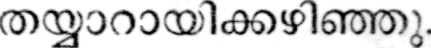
തയ്യാറായിക്കഴിഞ്ഞു.
